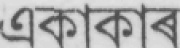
একাকাৰ
